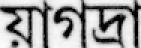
য়াগদ্রা
